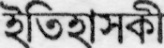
ইতিহাসকী
